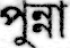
পুন্না
